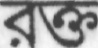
রক্ত
